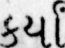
કર્યાં
